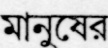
মানুষের
